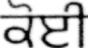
ਕੋਈ
